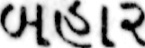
બહાર
